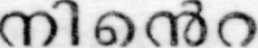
നിന്റെ
